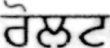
ਰੋਲਟ
